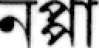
নপ্পা
